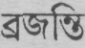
ব্ৰজন্তি
